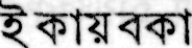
ইকায়বগা
